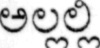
ಅಲ್ಲಲ್ಲಿ
